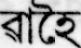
ৱাহৈ
